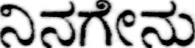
ನಿನಗೇನು
